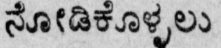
ನೋಡಿಕೊಳ್ಳಲು
